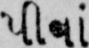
પીવાં
